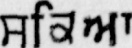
ਸਕਿਆ
